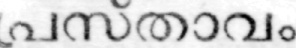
പ്രസ്താവം
